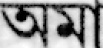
অমা
